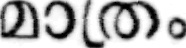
മാത്രം
